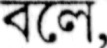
বলে,
